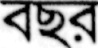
বছর
